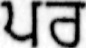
ਪਰ
